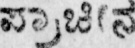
ಪ್ರಾಚೀನ
